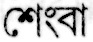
শেংবা
